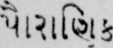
પૌરાણિક
